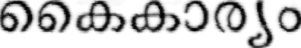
കൈകാര്യം
